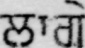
ਲਾਗੇ
